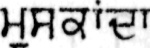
ਮੁਸਕਾਂਦਾ
